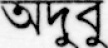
অদুবু
